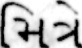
મિત્રે
